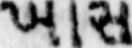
ખાસ
